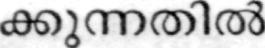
ക്കുന്നതില്‍
